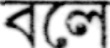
বলে
